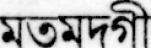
মতমদগী
